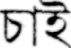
চাই
